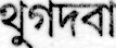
থুগদবা
